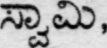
ಸ್ವಾಮಿ,
